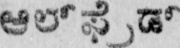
ಆಲ್ಫ್ರೆಡ್
